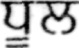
ਧੂਲ
